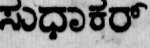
ಸುಧಾಕರ್
